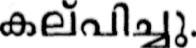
കല്പിച്ചു.
